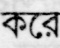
করে
